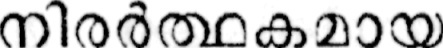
നിരര്‍ത്ഥകമായ
